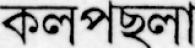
কলপছলা
